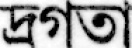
দ্রগতা
